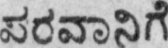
ಪರವಾನಿಗೆ
